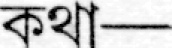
কথা-
